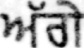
ਅੱਗੇ
